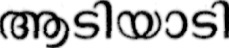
ആടിയാടി
